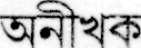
অনীখক
